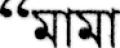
“মামা
